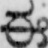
ಈ
